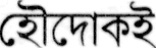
হৌদোকই
